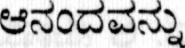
ಆನಂದವನ್ನು
